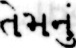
તેમનું
